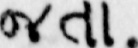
જતા.
